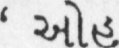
'ઓહ
